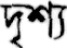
দৃশ্য
